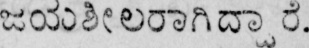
ಜಯಶೀಲರಾಗಿದ್ದಾರೆ.
